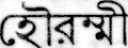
হৌরম্মী
